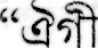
“ঐগী
